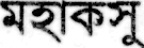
মহাকসু
